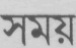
সময়
